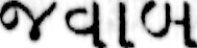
જવાબ
